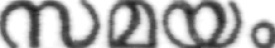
സമയം
